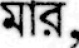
মার,
